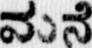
ಮನೆ
